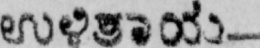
ಉಳಿತಾಯ-
